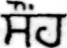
ਸੌਂਹ
